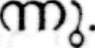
ന്നു.
